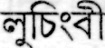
লুচিংবী
